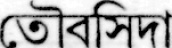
তৌবসিদা
